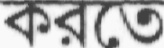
করতে
